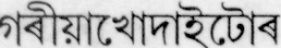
গৰীয়াখোদাইটোৰ
